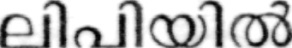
ലിപിയില്‍
